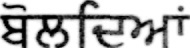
ਬੋਲਦਿਆਂ
